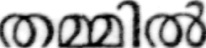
തമ്മില്‍
